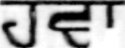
ਹਵਾ
